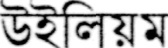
উইলিয়ম
